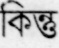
কিন্তু
